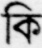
কি
